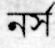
নর্স
